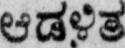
ಆಡಳಿತ
